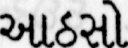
આઠસો
